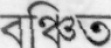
বঞ্চিত
